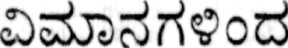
ವಿಮಾನಗಳಿಂದ
